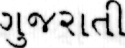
ગુજરાતી
